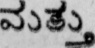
ಮತ್ತು
